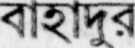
বাহাদুর
